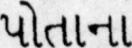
પોતાના
